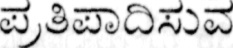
ಪ್ರತಿಪಾದಿಸುವ
